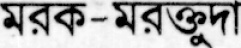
মরক-মরক্তুদা
